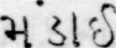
મંડાઈ
